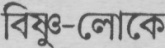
বিষ্ণু-লোকে
